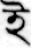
ই
